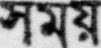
সময়
